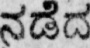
ನಡೆದ
